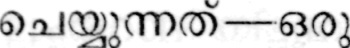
ചെയ്യുന്നത്-ഒരു
